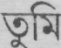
তুমি
